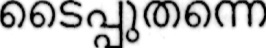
ടൈപ്പുതന്നെ
